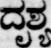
ದೃಶ್ಯ
